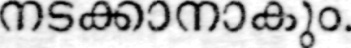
നടക്കാനാകും.
